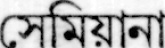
সেমিয়ানা
